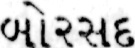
બોરસદ
